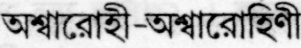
অশ্বারোহী-অশ্বারোহিণী
